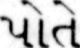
પોતે
